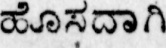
ಹೊಸದಾಗಿ
